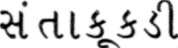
સંતાકૂકડી
